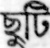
ছুটি
